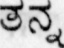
ತನ್ನ
